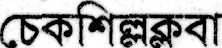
চেকশিল্লক্লবা
